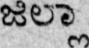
ಜಿಲ್ಲಾ
